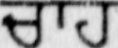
ਚਾਹ
